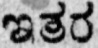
ಇತರ
